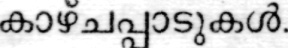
കാഴ്ചപ്പാടുകള്‍.
